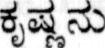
ಕೃಷ್ಣನು
